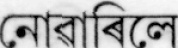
নোৱাৰিলে
